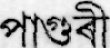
পাগুৰী
